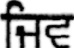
ਜਿਵ
